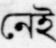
নেই
